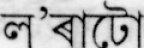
ল'ৰাটো
